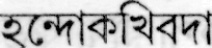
হন্দোকখিবদা
